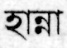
হান্না
